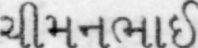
ચીમનભાઈ
